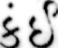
કંઇ
